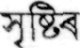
সৃষ্টিৰ
